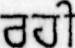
ਰਹੀ
